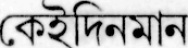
কেইদিনমান
